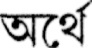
অর্থে
